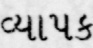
વ્યાપક
